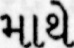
માથે
